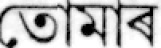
তোমাৰ
